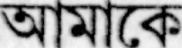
আমাকে
